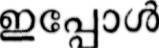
ഇപ്പോള്‍
